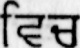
ਵਿਚ
